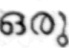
ഒരു
